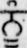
ਨੂੰ
